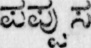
ಪಪ್ಪುಸ
